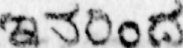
ಇವರಿಂದ
